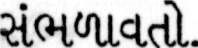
સંભળાવતો.
